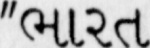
"ભારત
